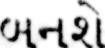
બનશે
